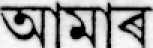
আমাৰ
